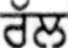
ਰੱਲ
